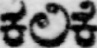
ಕಲಿಕೆ
